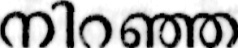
നിറഞ്ഞ
